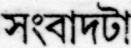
সংবাদটা
